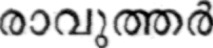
രാവുത്തര്‍
